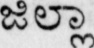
ಜಿಲ್ಲಾ
